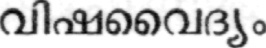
വിഷവൈദ്യം
